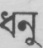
ধনু
